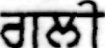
ਗਲੀ
